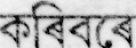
কৰিবৰে
